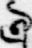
ঐ
